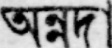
অন্নদা
